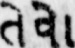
તેવો
